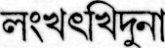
লংখৎখিদুনা
